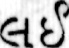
લઈ
